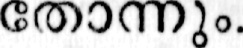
തോന്നും.
